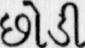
છોડી
